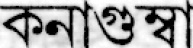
কনাগুম্বা
